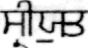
ਸ੍ਰੀਯੁਤ
